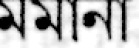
মমানা
